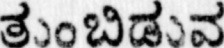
ತುಂಬಿಡುವ
